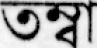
তম্বা
